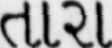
તારા
